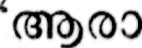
‘ആരാ
